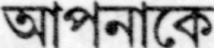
আপনাকে
